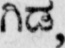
ಗಿಡ,
